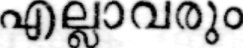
എല്ലാവരും
